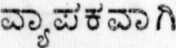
ವ್ಯಾಪಕವಾಗಿ
